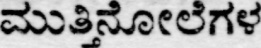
ಮುತ್ತಿನೋಲೆಗಳ
